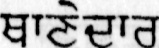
ਥਾਣੇਦਾਰ
